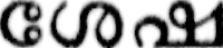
ശേഷ
